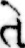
તે
